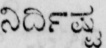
ನಿರ್ದಿಷ್ಟ
